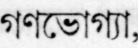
গণভোগ্যা,
